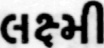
લક્ષ્મી
